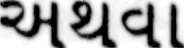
અથવા
